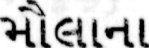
મૌલાના
